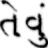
તેવું
